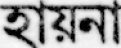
হায়না
